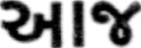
આજ
